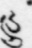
હું
